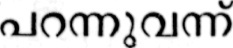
പറന്നുവന്ന്
